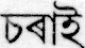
চৰাই
